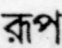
রূপ
